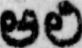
ಅಲಿ
